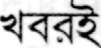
খবরই
